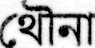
থৌনা
